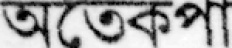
অতেকপা
